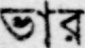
ভার
